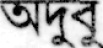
অদুবু
